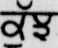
ਕੁੱਝ
